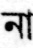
না
